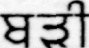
ਬੜੀ
